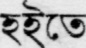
হইতে
